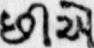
છીએ
